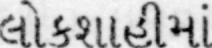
લોકશાહીમાં
